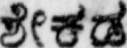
ಶೇಕಡ
